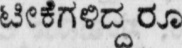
ಟೀಕೆಗಳಿದ್ದರೂ
